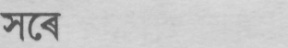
সৰে
